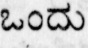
ಒಂದು
